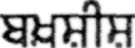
ਬਖ਼ਸ਼ੀਸ਼
